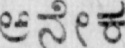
ಅನೇಕ
